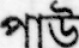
পাউ
